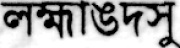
লহ্মাঙদসু
